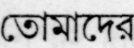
তোমাদের
